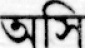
অসি
